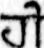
ਹੀ
